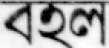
বহল
